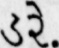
ડરે.
